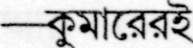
–কুমারেরই
